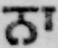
ਨਾ
